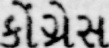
કોંગ્રેસ
